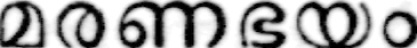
മരണഭയം
